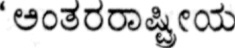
‘ಅಂತರರಾಷ್ಟ್ರೀಯ
